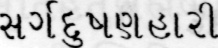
સર્ગદુષણહારી
